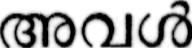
അവള്‍
